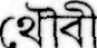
থৌবী
